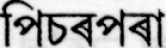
পিচৰপৰা
